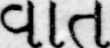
વાત
